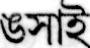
ঙসাই
